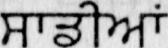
ਸਾਡੀਆਂ
